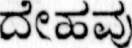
ದೇಹವು
